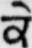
ਕੇ
